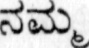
ನಮ್ಮ
